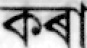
কৰা
